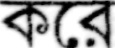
করে
